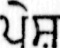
ਪੇਸ਼
